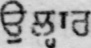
ਉਲ੍ਹਾਰ
